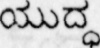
ಯುದ್ಧ
